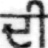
ਦੀ
